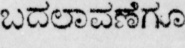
ಬದಲಾವಣೆಗೂ
